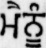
ਮੈਨੂੰ
